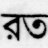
রত
